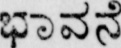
ಭಾವನೆ
